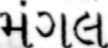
મંગલ
